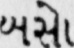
બસો
